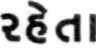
રહેતા
